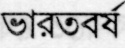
ভারতবর্ষ
